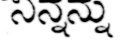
"ನಿನ್ನನ್ನು
